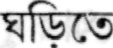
ঘড়িতে
